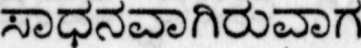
ಸಾಧನವಾಗಿರುವಾಗ
